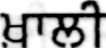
ਖ਼ਾਲੀ
